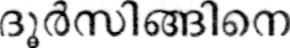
ദൂര്‍സിങ്ങിനെ
